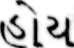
હોય
